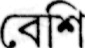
বেশি
